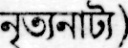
নৃত্যনাট্য)
